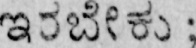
ಇರಬೇಕು;
